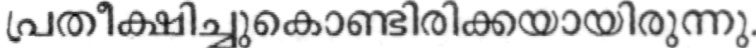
പ്രതീക്ഷിച്ചുകൊണ്ടിരിക്കയായിരുന്നു.
